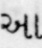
આ
